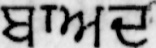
ਬਾਅਦ
